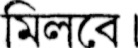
মিলবে।
